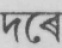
দৰে
